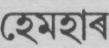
হেমহাৰ
